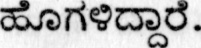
ಹೊಗಳಿದ್ದಾರೆ.
